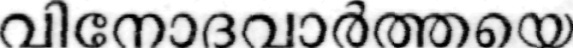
വിനോദവാര്‍ത്തയെ
